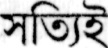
সত্যিই
